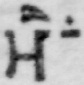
ਮੈਂ
